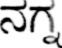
ನಗ್ನ
